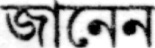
জানেন
